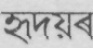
হৃদয়ৰ
